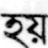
হয়
